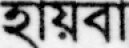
হায়বা
